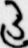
હે
